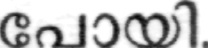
പോയി.
